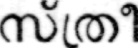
സ്ത്രീ
